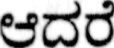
ಆದರೆ
